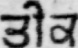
ਤੀਕ
